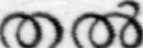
തല്‍
